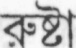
রুষ্টা
